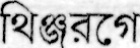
থিঞ্জরুগে
